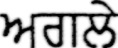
ਅਗਲੇ
